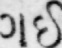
ગઈ
